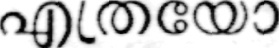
എത്രയോ
